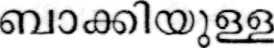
ബാക്കിയുള്ള
